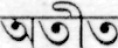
অতীত
